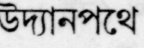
উদ্যানপথে
